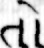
તો
